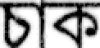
চাক
